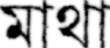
মাথা
